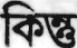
কিন্তু
